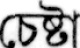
চেষ্টা
